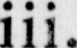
iii.
